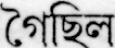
গৈছিল
